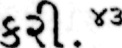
કરી.૪૩
